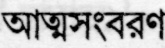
আত্মসংবরণ
